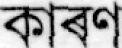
কাৰণ
